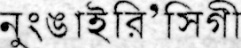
নুংঙাইরি’সিগী
